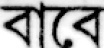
বাবে
